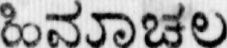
ಹಿಮಾಚಲ
